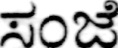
ಸಂಜೆ
